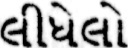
લીધેલો
